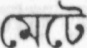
মেটে
